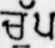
ਚੁੱਪ
